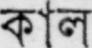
কাল
